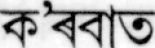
ক'ৰবাত
